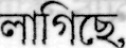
লাগিছে,
